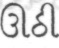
ઊઠી
